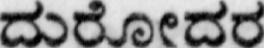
ದುರೋದರ
